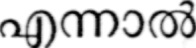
എന്നാല്‍
